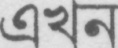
এখন
